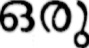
ഒരു
